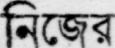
নিজের
